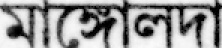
মাঙ্গোলদা
